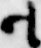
ન
